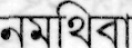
নমথিবা
